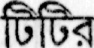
টিটির
